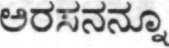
ಅರಸನನ್ನೂ
